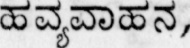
ಹವ್ಯವಾಹನ,
